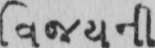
વિજયની
